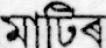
মাটিৰ
